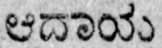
ಆದಾಯ
